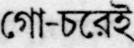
গো-চরেই
